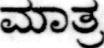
ಮಾತ್ರ
